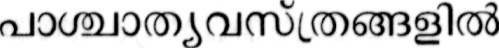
പാശ്ചാത്യവസ്ത്രങ്ങളില്‍
